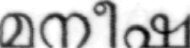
മനീഷ
